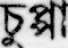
চুপ্পা
